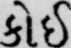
કોઈ
